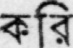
করি
